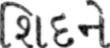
શિદને
